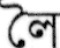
লৈ
